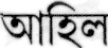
আহিল
